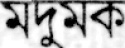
মদুমক
